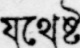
যথেষ্ট
